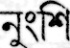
নুংশি
